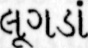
લૂગડાં
